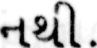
નથી.
